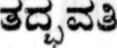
ತದ್ಭವತಿ
